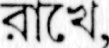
রাখে,
